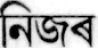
নিজৰ
